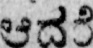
ಆದರೆ
